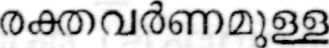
രക്തവര്‍ണമുള്ള
